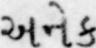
અનેક
